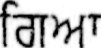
ਗਿਆ
